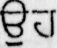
ਉਹ
